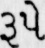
રૂપે
